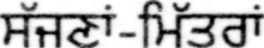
ਸੱਜਣਾਂ-ਮਿੱਤਰਾਂ
